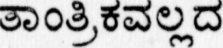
ತಾಂತ್ರಿಕವಲ್ಲದ
